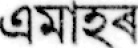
এমাহৰ
